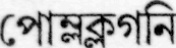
পোম্লক্লগনি
